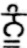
ਨੂੰ
